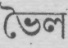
ভৈল
